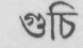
গুচি
